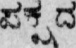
ಪಕ್ಷದ
